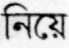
নিয়ে
